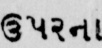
ઉપરના
